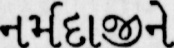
નર્મદાજીને
